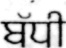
ਬੱਧੀ
